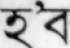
হ'ব
